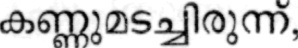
കണ്ണുമടച്ചിരുന്ന്,
